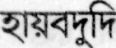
হায়বদুদি
